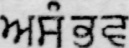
ਅਸੰਭਵ
